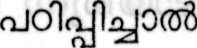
പഠിപ്പിച്ചാല്‍
